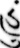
હું
